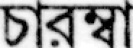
চারম্বা
